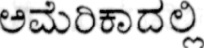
ಅಮೆರಿಕಾದಲ್ಲಿ
